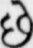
છે
